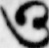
ও
